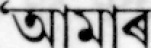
'আমাৰ
